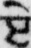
ਏ
